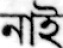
নাই
